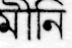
মীনি
